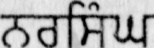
ਨਰਸਿੰਘ
